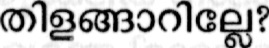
തിളങ്ങാറില്ലേ?
